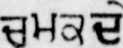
ਚਮਕਦੇ
